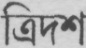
ত্ৰিদশ
